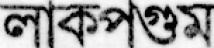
লাকপগুম
